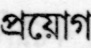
প্রয়োগ
